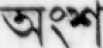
অংশ
